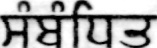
ਸੰਬੰਧਿਤ
